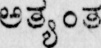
ಅತ್ಯಂತ
